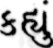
કહ્યું
